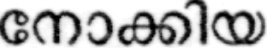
നോക്കിയ
